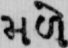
મળે
